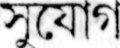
সুযোগ
